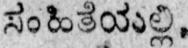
ಸಂಹಿತೆಯಲ್ಲಿ,
